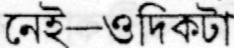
নেই—ওদিকটা
